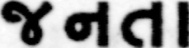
જનતા
